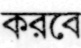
করবে
